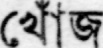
খোঁজ
